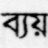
ব্যয়
